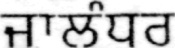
ਜਾਲੰਧਰ
